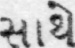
સાથે
